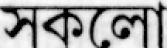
সকলো
